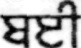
ਬਈ
